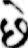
છે
